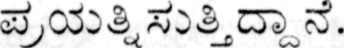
ಪ್ರಯತ್ನಿಸುತ್ತಿದ್ದಾನೆ.
